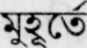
মুহূর্তে
